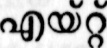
എയ്റ്റ്
